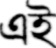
এই
